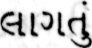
લાગતું
